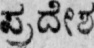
ಪ್ರದೇಶ
